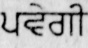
ਪਵੇਗੀ
